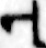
ન
